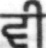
ਵੀ
